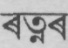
ৰত্নৰ
